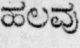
ಹಲವು
